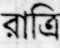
রাত্রি
